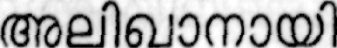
അലിഖാനായി
